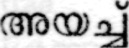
അയച്ച്
